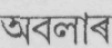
অবলাৰ
